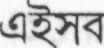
এইসব
